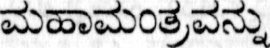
ಮಹಾಮಂತ್ರವನ್ನು
